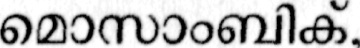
മൊസാംബിക്.
